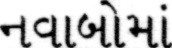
નવાબોમાં
